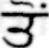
ਤੋਂ
